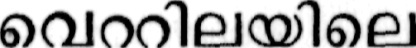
വെററിലയിലെ
